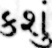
કશું
